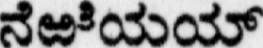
ನೆಱೆಯಯ್
